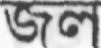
জল
